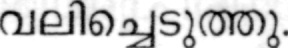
വലിച്ചെടുത്തു.
